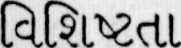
વિશિષ્ટતા
